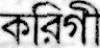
করিগী
